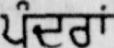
ਪੰਦਰਾਂ
